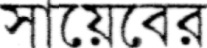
সায়েবের
